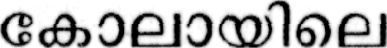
കോലായിലെ
